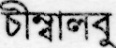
চীম্বালবু
